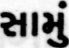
સામું
